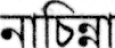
নাচিন্না
